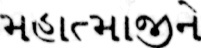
મહાત્માજીને
